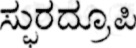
ಸ್ಫುರದ್ರೂಪಿ
